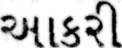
આકરી
